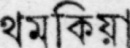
থমকিয়া
